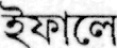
ইফালে
